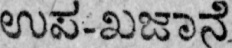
ಉಪ-ಖಜಾನೆ
